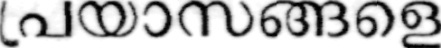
പ്രയാസങ്ങളെ
